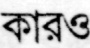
কারও
